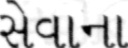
સેવાના
